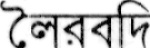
লৈরবদি
